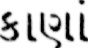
કાણાં
